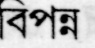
বিপন্ন
